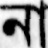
না
